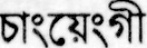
চাংয়েংগী
